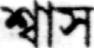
শ্বাস
